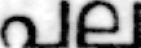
പല
